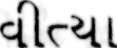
વીત્યા
